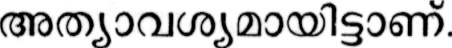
അത്യാവശ്യമായിട്ടാണ്.
